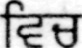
ਵਿਚ
